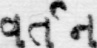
વર્તન
